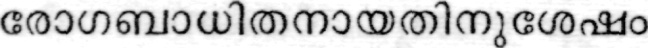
രോഗബാധിതനായതിനുശേഷം
